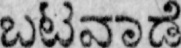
ಬಟವಾಡೆ
